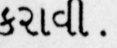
કરાવી.
